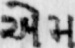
એમ
